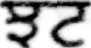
ਝਟ
